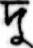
দু
